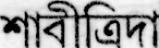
শাবীত্রিদা
